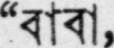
‘‘বাবা,
